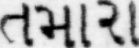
તમારા
